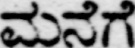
ಮನೆಗೆ
